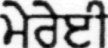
ਮੇਰੇਈ
